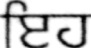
ਇਹ
